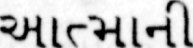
આત્માની
